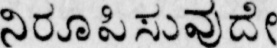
ನಿರೂಪಿಸುವುದೇ
